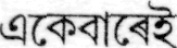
একেবাৰেই
